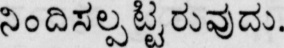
ನಿಂದಿಸಲ್ಪಟ್ಟಿರುವುದು.
